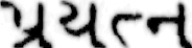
પ્રયત્ન
